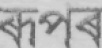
ৰূপৰ
